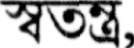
স্বতন্ত্র,
